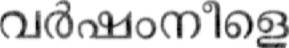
വര്‍ഷംനീളെ
